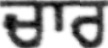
ਚਾਰ
